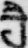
ਹੈ
